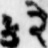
કરે
